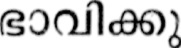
ഭാവിക്കു
